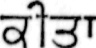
ਕੀਤਾ
